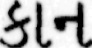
કાન
